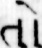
તો
